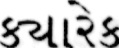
ક્યારેક
